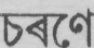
চৰণে
